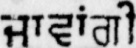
ਜਾਵਾਂਗੀ
